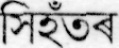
সিহঁতৰ
